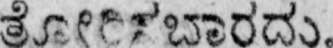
ತೋರಿಸಬಾರದು.
